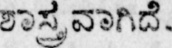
ಶಾಸ್ತ್ರವಾಗಿದೆ.
